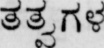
ತತ್ವಗಳ
